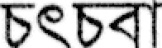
চৎচবা
